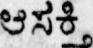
ಆಸಕ್ತಿ
